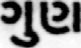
ગુણ
